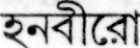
হনবীরো
